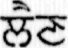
ਲੈਣ
